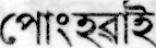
পোংহৱাই
